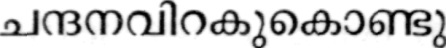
ചന്ദനവിറകുകൊണ്ടു
